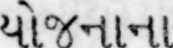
યોજનાના
